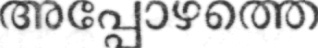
അപ്പോഴത്തെ
